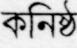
কনিষ্ঠ
